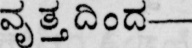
ವೃತ್ತದಿಂದ-
